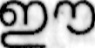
ഈ
